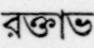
রক্তাভ
